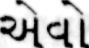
એવો
